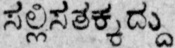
ಸಲ್ಲಿಸತಕ್ಕದ್ದು
